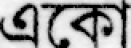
একো
